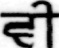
ਵੀ
